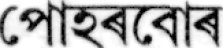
পোহৰবোৰ
